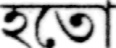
হতো
